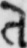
તે
